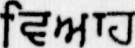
ਵਿਆਹ
